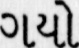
ગયો
